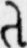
તે
